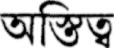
অস্তিত্ব
